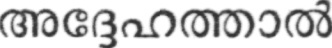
അദ്ദേഹത്താല്‍
